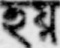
হয়
